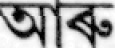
আৰু
